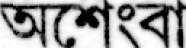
অশেংবা
